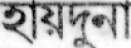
হায়দুনা
